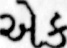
એક
